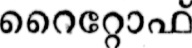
റൈറ്റോഫ്
